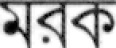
মরক
